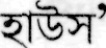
হাউস’
